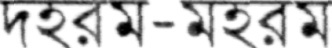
দহরম-মহরম
